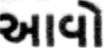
આવો
